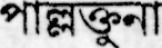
পাল্লক্তুনা
